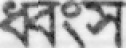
ধ্বংস
